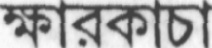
ক্ষারকাচা
